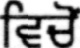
ਵਿਚੋਂ
